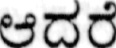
ಆದರೆ
